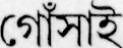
গোঁসাই
